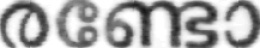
രണ്ടോ
